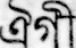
ঐগী
